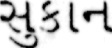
સુકાન
